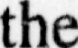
the
